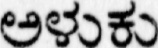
ಅಳುಕು
